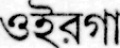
ওইরগা
